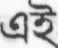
এই
